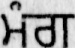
ਮੰਗ
